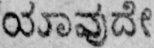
ಯಾವುದೇ
